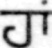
ਹਾਂ
